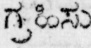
ಗ್ರಹಿಸು
